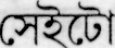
সেইটো
